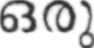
ഒരു
